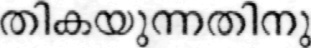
തികയുന്നതിനു
